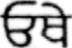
ਓਥੇ
